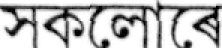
সকলোৰে
